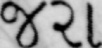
જરા
